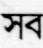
সব
